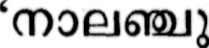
‘നാലഞ്ചു
